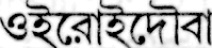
ওইরোইদৌবা
